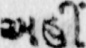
અહીં
